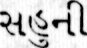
સહુની
